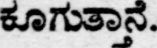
ಕೂಗುತ್ತಾನೆ.
